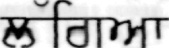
ਲੱਗਿਆ
